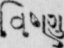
વિષ્ણુ
